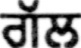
ਗੱਲ
